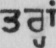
ਤਰ੍ਹਾਂ
